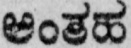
ಅಂತಹ
